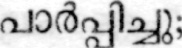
പാര്‍പ്പിച്ചു;
